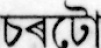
চৰটো
